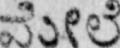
ಮೇಲೆ
